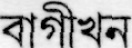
বাগীখন
